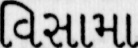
વિસામા
